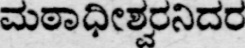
ಮಠಾಧೀಶ್ವರನಿದರ
